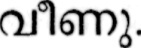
വീണു.
